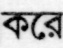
করে
